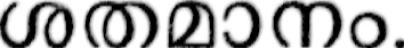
ശതമാനം.
